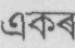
একৰ
